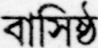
বাসিষ্ঠ
